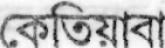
কেতিয়াবা
